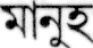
মানুহ
